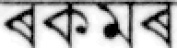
ৰকমৰ
